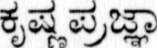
ಕೃಷ್ಣಪ್ರಜ್ಞಾ
